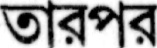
তারপর
